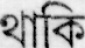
থাকি
